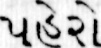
પહેરો
